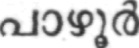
പാഴൂര്‍
